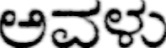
ಅವಳು
